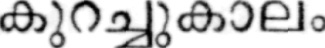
കുറച്ചുകാലം
